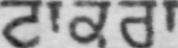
ਟਾਕਰਾ
